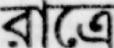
রাত্রে
